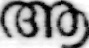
ആ
